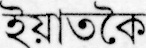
ইয়াতকৈ
